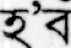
হ'ব
